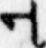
ન
